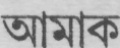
আমাক
